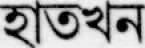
হাতখন
